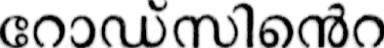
റോഡ്സിന്റെ
